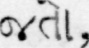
જતો,
